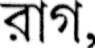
রাগ,
